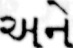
અને
